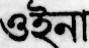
ওইনা
